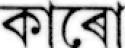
কাৰো
